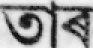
তাৰ
